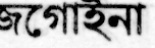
জগোইনা
